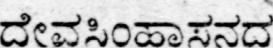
ದೇವಸಿಂಹಾಸನದ
